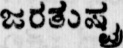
ಜರತುಷ್ಟ್ರ
